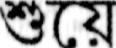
শুয়ে
